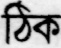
ঠিক
